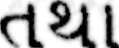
તથા
